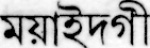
ময়াইদগী
